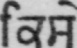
ਕਿਸੇ
